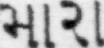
મારા
